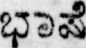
ಭಾಷೆ
